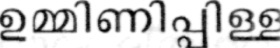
ഉമ്മിണിപ്പിള്ള
